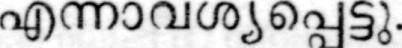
എന്നാവശ്യപ്പെട്ടു.
